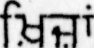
ਖ਼ਿਜ਼ਾਂ
